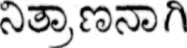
ನಿತ್ರಾಣನಾಗಿ
